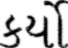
કર્યો
